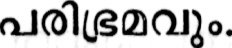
പരിഭ്രമവും.
